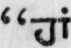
''ਹਾਂ
